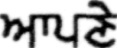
ਆਪਣੇ
